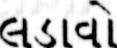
લડાવો
